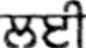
ਲਈ
